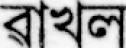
ৱাখল
